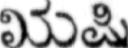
ಋಷಿ
